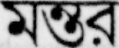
মন্তর
